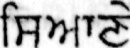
ਸਿਆਣੇ
